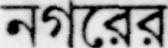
নগরের
